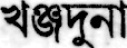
খঞ্জদুনা
